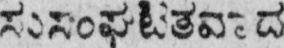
ಸುಸಂಘಟಿತವಾದ
